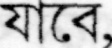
যাবে,
